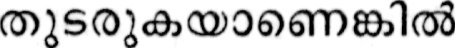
തുടരുകയാണെങ്കില്‍
